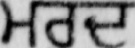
ਮਰਦ
